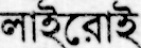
লাইরোই
